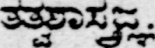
ತತ್ವಶಾಸ್ತ್ರಜ್ಞ.
